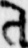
તે
